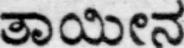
ತಾಯೀನ
